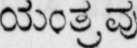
ಯಂತ್ರವು
